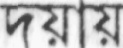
দয়ায়
